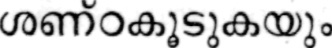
ശണ്ഠകൂടുകയും
